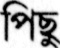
পিছু
